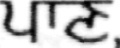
ਪਾਣ,
